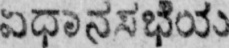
ವಿಧಾನಸಭೆಯ
